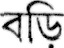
বড়ি
